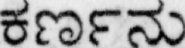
ಕರ್ಣನು
